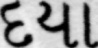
દયા
